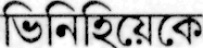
ভিনিহিয়েকে
